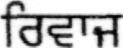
ਰਿਵਾਜ
